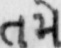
તમે
